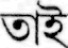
তাই
